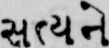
સત્યને
